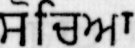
ਸੋਚਿਆ
